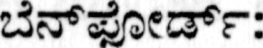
ಬೆನ್‌ಫೋರ್ಡ್:
